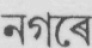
নগৰে
